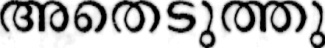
അതെടുത്തു
